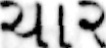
ચાર
